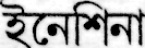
ইনেশিনা
